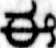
ಈ
